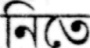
নিতে
